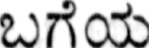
ಬಗೆಯ
